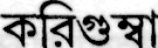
করিগুম্বা
